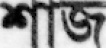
শাজ
